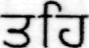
ਤਹਿ
